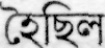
হৈছিল
